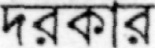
দরকার
